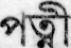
পত্নী
